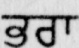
ਭਰਾ
